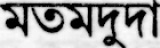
মতমদুদা
